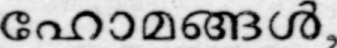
ഹോമങ്ങള്‍,
